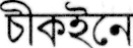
চীকইনে
